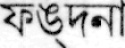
ফঙদনা
